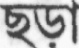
ছড়া
